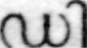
ഡി
